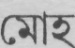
মোহ
